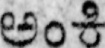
ಅಂಕಿ
